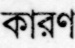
কারণ
